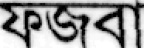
ফজবা
